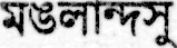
মঙলান্দসু
